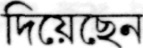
দিয়েছেন
